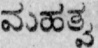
ಮಹತ್ವ
